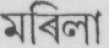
মৰিলা
